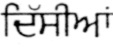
ਦਿੱਸੀਆਂ
